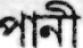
পানী
